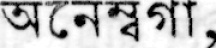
অনেম্বগা,
